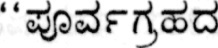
"ಪೂರ್ವಗ್ರಹದ
